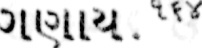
ગણાય.૧૬૪
